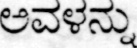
ಅವಳನ್ನು
